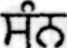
ਸੰਨ
